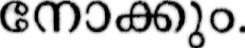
നോക്കും.
